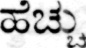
ಹೆಚ್ಚು
